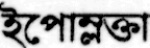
ইপোম্লক্তা
